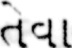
તેવા
